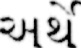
અર્થે
